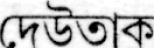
দেউতাক
